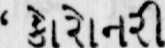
'કોરોનરી
